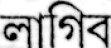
লাগিব
